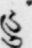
હું
